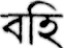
বহি
